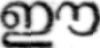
ഈ
